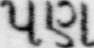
પણ
